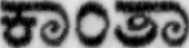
ಕಾಂತಾ
